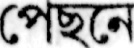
পেছনে
